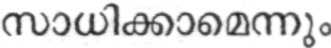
സാധിക്കാമെന്നും
